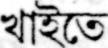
খাইতে
